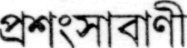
প্রশংসাবাণী
